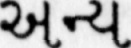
અન્ય
